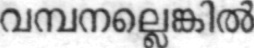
വമ്പനല്ലെങ്കില്‍
